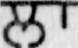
ਲਾ
